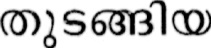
തുടങ്ങിയ
